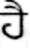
ਹੈ
